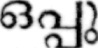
ഒപ്പു
